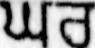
ਘਰ
